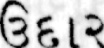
ઉદાર
